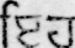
ਇਹ
